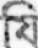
যি
